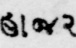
હાજર
